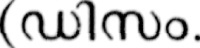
(ഡിസം.
